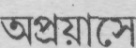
অপ্ৰয়াসে
